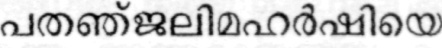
പതഞ്ജലിമഹര്‍ഷിയെ
